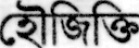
হৌজিক
